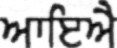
ਆਇਐ
